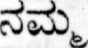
ನಮ್ಮ
